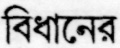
বিধানের
